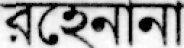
রহেনানা
